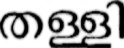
തള്ളി
